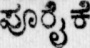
ಪೂರೈಕೆ
